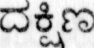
ದಕ್ಷಿಣ
